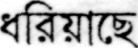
ধরিয়াছে
